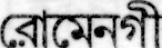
রোমেনগী
